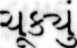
ચૂક્યું
